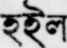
হইল
